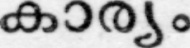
കാര്യം
